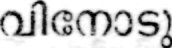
വിനോടു
